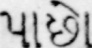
પાછો
